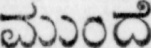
ಮುಂದೆ
